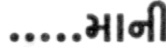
......માની
